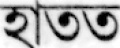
হাতত
